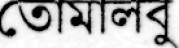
তোমালবু
